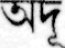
অদূ
